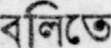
বলিতে
